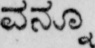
ವನ್ನೂ
